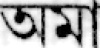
অমা
